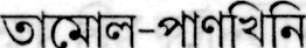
তামোল-পাণখিনি
